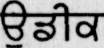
ਉਡੀਕ
